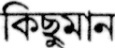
কিছুমান
